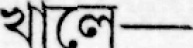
খালে-
